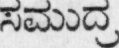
ಸಮುದ್ರ
